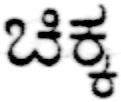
ಚಿಕ್ಕ
